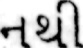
નથી
